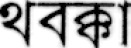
থবক্কা
